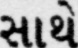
સાથે
